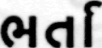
ભર્તા
